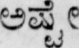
ಅಷ್ಟೇ
